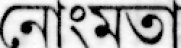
নোংমতা
